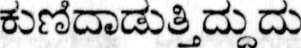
ಕುಣಿದಾಡುತ್ತಿದ್ದುದು
